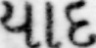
યાદ
